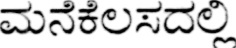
ಮನೆಕೆಲಸದಲ್ಲಿ
